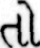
તો
